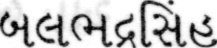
બલભદ્રસિંહ
